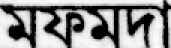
মফমদা
